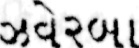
ઝવેરબા
